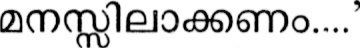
മനസ്സിലാക്കണം....’
